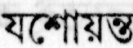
যশোয়ন্ত
